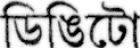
ডিঙিটো
